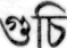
গুচি
